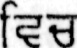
ਵਿਚ
